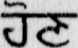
ਹੋਣ
